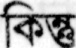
কিন্তু
